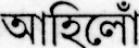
আহিলোঁ
